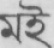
মই
